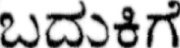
ಬದುಕಿಗೆ
